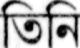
তিনি
